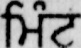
ਮਿੰਟ
